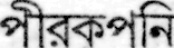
পীরকপনি
